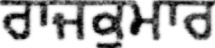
ਰਾਜਕੁਮਾਰ
